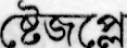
ষ্টেজপ্লে
